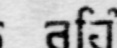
ਰਹਿ''
